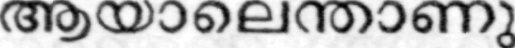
ആയാലെന്താണു
